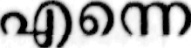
എന്നെ
